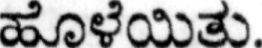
ಹೊಳೆಯಿತು.
